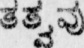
ತತ್ವವು
